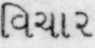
વિચાર
